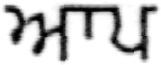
ਆਪ
